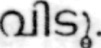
വിടൂ.
